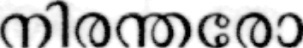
നിരന്തരോ
